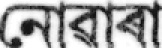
নোৱাৰা
